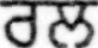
ਰਲ
